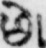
છો
